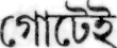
গোটেই
